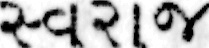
સ્વરાજ
